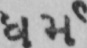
ધર્મ
